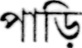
পাড়ি
